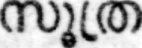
സൂത്ര
